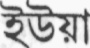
ইউয়া
